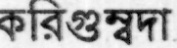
করিগুম্বদা
